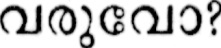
വരുവോ?
